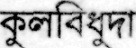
কুলবিধূদা
